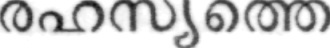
രഹസ്യത്തെ
